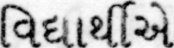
વિધાર્થીએ
